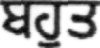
ਬਹੁਤ
